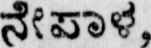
ನೇಪಾಳ,
